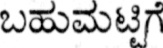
ಬಹುಮಟ್ಟಿಗೆ
